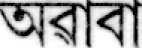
অৱাবা
